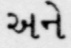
અને
